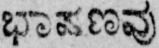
ಭಾಷಣವು
